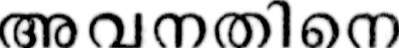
അവനതിനെ
